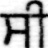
ਸੀ
